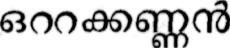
ഒററക്കണ്ണന്‍
